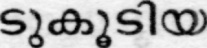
ടുകൂടിയ
